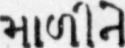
માળીને
